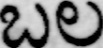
ಬಲ
